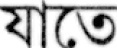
যাতে
